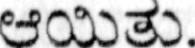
ಆಯಿತು.
